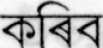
কৰিব
